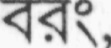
বরং,
